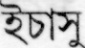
ইচাসু
